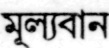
মূল্যবান
